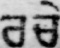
ਰਚੇ
